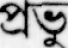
প্রভু
